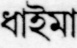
ধাইমা
